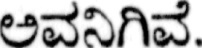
ಅವನಿಗಿವೆ.
